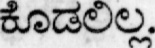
ಕೊಡಲಿಲ್ಲ.
